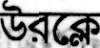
উরক্লে
